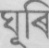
ঘূৰি
